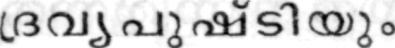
ദ്രവ്യപുഷ്ടിയും
